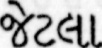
જેટલા
